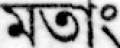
মতাং
